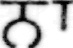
ਨਾ
